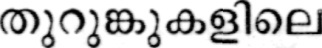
തുറുങ്കുകളിലെ
